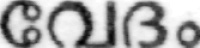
വേദം
